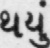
થયું
